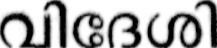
വിദേശി
